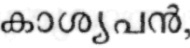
കാശ്യപന്‍,
